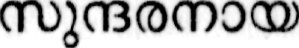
സുന്ദരനായ
